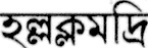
হল্লক্লমদ্রি
